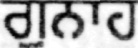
ਗੁਨਾਹ
